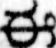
ಈ
